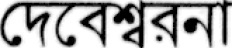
দেবেশ্বরনা
